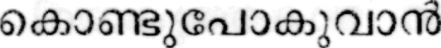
കൊണ്ടുപോകുവാന്‍
